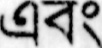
এবং
